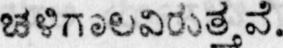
ಚಳಿಗಾಲವಿರುತ್ತವೆ.
